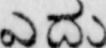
ಎದು
